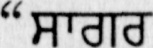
''ਸਾਗਰ
